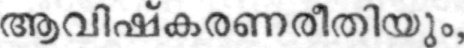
ആവിഷ്കരണരീതിയും,
